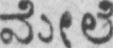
ಮೇಲೆ
